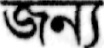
জন্য
